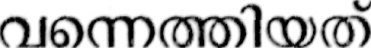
വന്നെത്തിയത്
